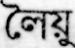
লৈয়ু
